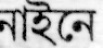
নাইনে
